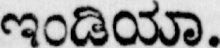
ಇಂಡಿಯಾ.
